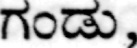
ಗಂಡು,
